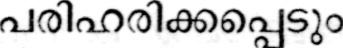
പരിഹരിക്കപ്പെടും
